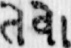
તેવો
